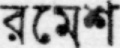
রমেশ
